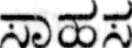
ಸಾಹಸ
